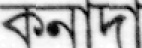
কনাদা
